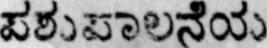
ಪಶುಪಾಲನೆಯ
